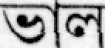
ভাল
